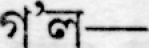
গ'ল-
